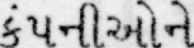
કંપનીઓને
